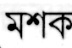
মশক
